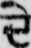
ਦੇ
